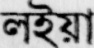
লইয়া
